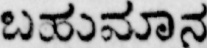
ಬಹುಮಾನ
